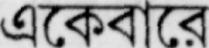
একেবারে
